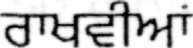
ਰਾਖਵੀਆਂ
